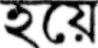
হয়ে
